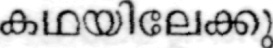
കഥയിലേക്കു
